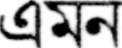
এমন
